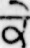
ਕੇ
